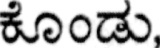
ಕೊಂಡು,
